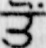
ਤੋਂ
